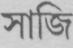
সাজি
